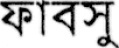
ফাবসু
